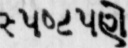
સ્પષ્ટપણે
